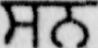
ਸਨ
